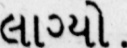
લાગ્યો.
